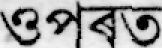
ওপৰত
